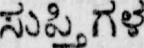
ಸುಪ್ತಿಗಳ
